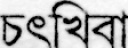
চৎখিবা
